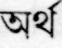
অর্থ
